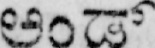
ಅಂಡ್
